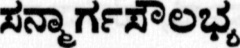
ಸನ್ಮಾರ್ಗಸೌಲಭ್ಯ
